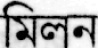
মিলন
